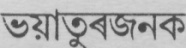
ভয়াতুৰজনক
